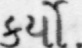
કર્યો.
